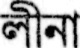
লীনা
